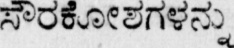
ಸೌರಕೋಶಗಳನ್ನು
